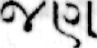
જણ
